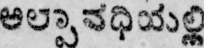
ಅಲ್ಪಾವಧಿಯಲ್ಲಿ
